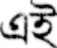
এই
